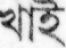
খাই
